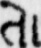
તો
